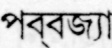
পব্বজ্যা
